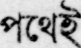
পথেই
